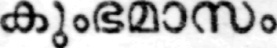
കുംഭമാസം
